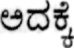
ಅದಕ್ಕೆ
